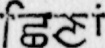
ਛਿਣਾਂ
